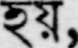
হয়,
